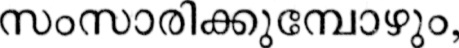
സംസാരിക്കുമ്പോഴും,
